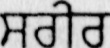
ਸਰੀਰ
